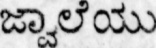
ಜ್ವಾಲೆಯು
